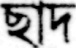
ছাদ
